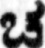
ಚ
